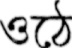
ওঠে
